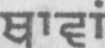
ਥਾਵਾਂ
